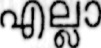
എല്ലാ
